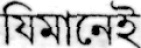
যিমানেই
